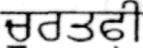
ਚੁਰਤਫ਼ੀ
